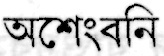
অশেংবনি
